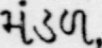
મંડળ,
